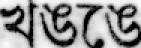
খঙঙে
